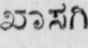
ಖಾಸಗಿ
